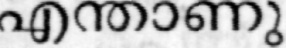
എന്താണു
